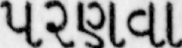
પરણવા
